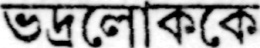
ভদ্রলোককে
